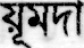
য়ুমদা
